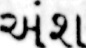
અંશ
